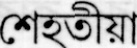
শেহতীয়া
